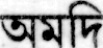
অমদি
